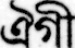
ঐগী
